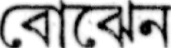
বোঝেন
